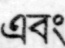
এবং
